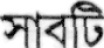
সাবটি
